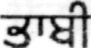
ਭਾਬੀ
